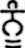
ਨੂੰ
